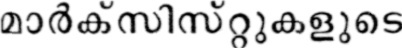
മാര്‍ക്സിസ്റ്റുകളുടെ
